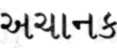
અચાનક
